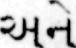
અને
